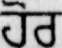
ਹੋਰ
